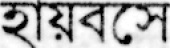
হায়বসে
